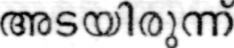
അടയിരുന്ന്
